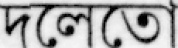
দলেতো
